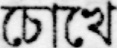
চোখে
